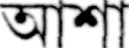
আশা
